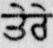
ਤੇਰੇ
